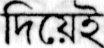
দিয়েই
